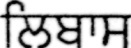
ਲਿਬਾਸ
